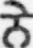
ਨੇ
